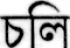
চলি
